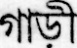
গাড়ী
